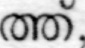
ത്ത്,
